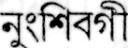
নুংশিবগী
